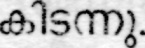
കിടന്നു.
